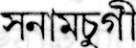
সনামচুগী
